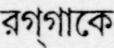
রগ্গাকে
